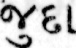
જુદા
